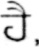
ਹੈ,
